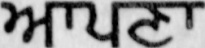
ਆਪਣਾ
